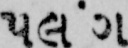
પલંગ
